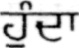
ਹੁੰਦਾ
